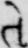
તે
